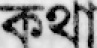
কথা
